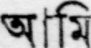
আমি
